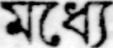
মধ্যে
